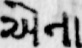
એના
